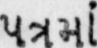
પત્રમાં
